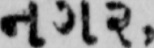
નગર,
